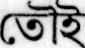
তৌই
